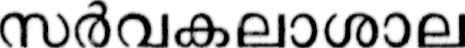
സര്‍വകലാശാല
